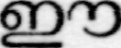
ഈ
